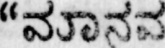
“ಮಾನವ
